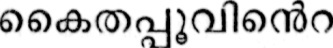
കൈതപ്പൂവിന്റെ
